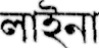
লাইনা
